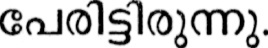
പേരിട്ടിരുന്നു.
